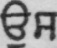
ਉਸ
